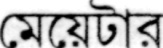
মেয়েটার
